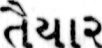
તૈયાર
